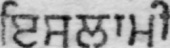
ਇਸਲਾਮੀ
